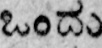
ಒಂದು
